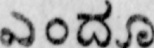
ಎಂದೂ
